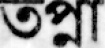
তপ্না
